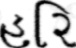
હરિ
